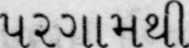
પરગામથી
